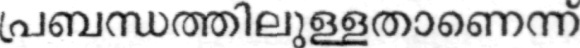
പ്രബന്ധത്തിലുള്ളതാണെന്ന്
